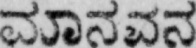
ಮಾನವನ
